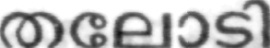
തലോടി
